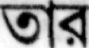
তার
